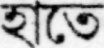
হাতে
